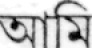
আমি
